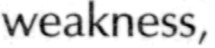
weakness,
